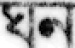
ঘন
